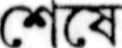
শেষে
